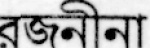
রজনীনা
